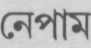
নেপাম
